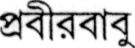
প্রবীরবাবু
